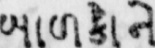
બાળકોને
